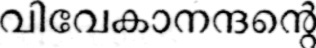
വിവേകാനന്ദന്റെ
